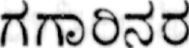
ಗಗಾರಿನರ
